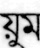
য়ুম
